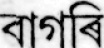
বাগৰি
